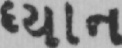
ધ્યાન
